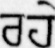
ਰਹੇ
